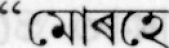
"মোৰহে
